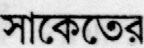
সাকেতের
